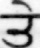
ਤੇ
